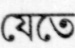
যেতে
